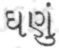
ઘણું
